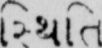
સ્થિતિ
